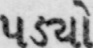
પડ્યો
